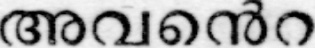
അവന്റെ
